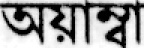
অয়াম্বা
